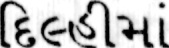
દિલ્હીમાં
